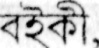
বইকী,
